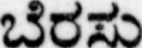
ಬೆರಸು
